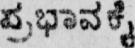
ಪ್ರಭಾವಕ್ಕೆ
